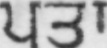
ਪਤਾ
